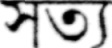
সত্য
